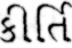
કીર્તિ
